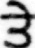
ਤੇ
